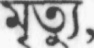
মৃত্যু,
